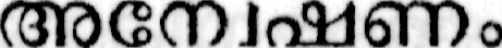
അന്വേഷണം
